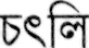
চৎলি
